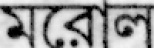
মরোল
